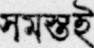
সমস্তই
